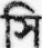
সি
